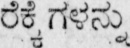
ರೆಕ್ಕೆಗಳನ್ನು
